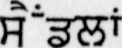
ਸੈਂਡਲਾਂ
